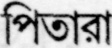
পিতারা
